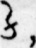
કે,
